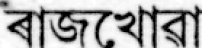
ৰাজখোৱা
